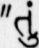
"તું
